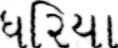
ધરિયા
